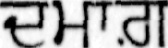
ਦਮਾਗ਼
